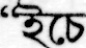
“ইচে
